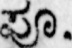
ಪೂ.
